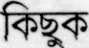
কিছুক
